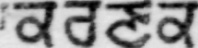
ਕਰਣਕ
